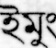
ইমুং
